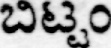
ಬಿಟ್ಟಂ
